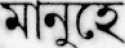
মানুহে
